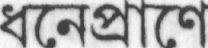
ধনেপ্রাণে
